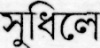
সুধিলে
